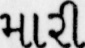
મારી
